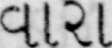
વારા
